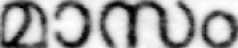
മാസം
